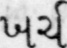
ખર્ચ
